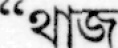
“থাজ
